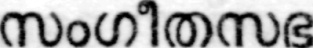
സംഗീതസഭ
